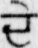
ਦੇ
